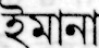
ইমানা
